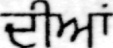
ਦੀਆਂ
